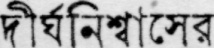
দীর্ঘনিশ্বাসের
